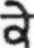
ਕੇ
